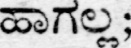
ಹಾಗಲ್ಲ;
